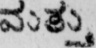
ಮತ್ತು
